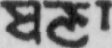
ਬਣਾ
